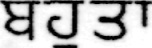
ਬਹੁਤਾ
